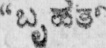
“ಬೃಹತ್
